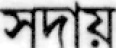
সদায়
